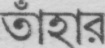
তাঁহার
